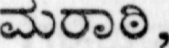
ಮರಾಠಿ,
